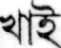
খাই
